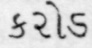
કરોડ
